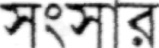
সংসার
